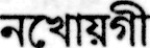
নখোয়গী
